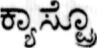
ಕ್ಯಾಸ್ಟ್ರೊ
